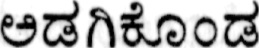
ಅಡಗಿಕೊಂಡ
